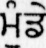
ਮੁੰਡੇ
